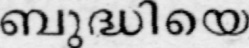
ബുദ്ധിയെ
